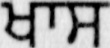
ਖਾਸ
